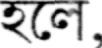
হলে,
